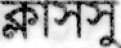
ক্লাসসু
